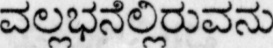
ವಲ್ಲಭನೆಲ್ಲಿರುವನು
